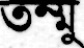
তম্মু
